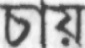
চায়
